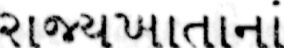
રાજ્યખાતાનાં
